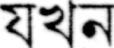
যখন
